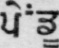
ਪੇਂਡੂ
